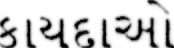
કાયદાઓ
